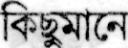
কিছুমানে
